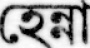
হেন্না
